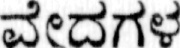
ವೇದಗಳ
